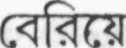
বেরিয়ে
